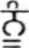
ਨੂੰ
